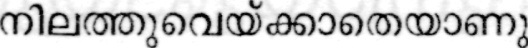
നിലത്തുവെയ്ക്കാതെയാണു
